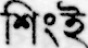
শিংই
